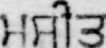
ਮਸੀਤ
